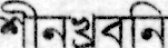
শীনখ্রবনি
